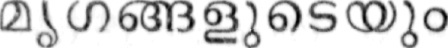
മൃഗങ്ങളുടെയും
